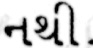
નથી.
